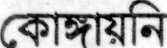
কোঙ্গায়নি
